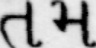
તમ
